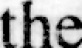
the
